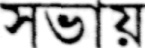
সভায়
